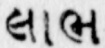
લાભ
